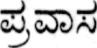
ಪ್ರವಾಸ
